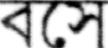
বসে
